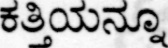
ಕತ್ತಿಯನ್ನೂ
